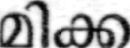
മിക്ക
